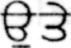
ਉਤੇ
